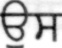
ਉਸ
